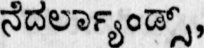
ನೆದರ್ಲ್ಯಾಂಡ್ಸ್,
